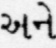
અને
